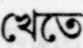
খেতে
